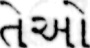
તેઓ
